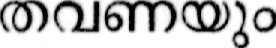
തവണയും
